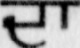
ਦਾ
